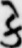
કે
